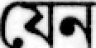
যেন
